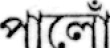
পালোঁ
